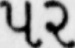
પર
